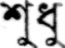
শুধু
